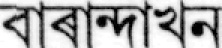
বাৰান্দাখন
